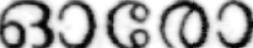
ഓരോ
